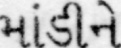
માંડીને
